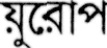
য়ুরোপ
